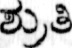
ಶ್ರುತಿ
